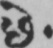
છે.
